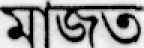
মাজত
